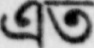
এত
